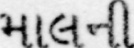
માલની
